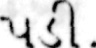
પડી.
